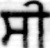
ਸੀ
